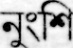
নুংশি
